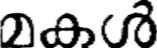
മകള്‍
